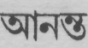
আনন্ত
